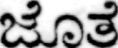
ಜೊತೆ
